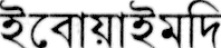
ইবোয়াইমদি
